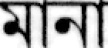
মানা
